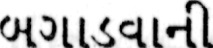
બગાડવાની
